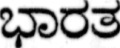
ಭಾರತ
